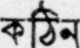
কঠিন
